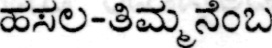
ಹಸಲ-ತಿಮ್ಮನೆಂಬ
